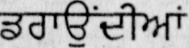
ਡਰਾਉਂਦੀਆਂ
